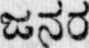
ಜನರ
